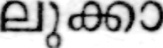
ലുക്കാ
